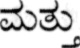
ಮತ್ತು
